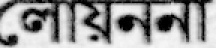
লোয়ননা
